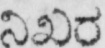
ನಿಖರ
